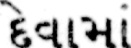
દેવામાં
